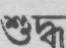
শুদ্ধ
